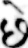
છે
